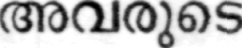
അവരുടെ
